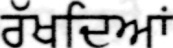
ਰੱਖਦਿਆਂ
